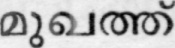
മുഖത്ത്
